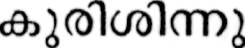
കുരിശിന്നു
